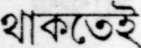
থাকতেই
